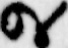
જ
